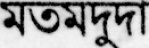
মতমদুদা
